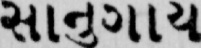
સાનુગાય
